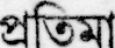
প্রতিমা
